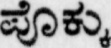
ಪೊಕ್ಕು
